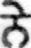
ਨੇ
